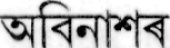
অবিনাশৰ
